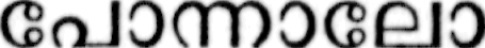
പോന്നാലോ
